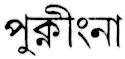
পুক্নীংনা
